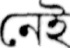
নেই
